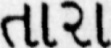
તારા
